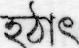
হঠাৎ
